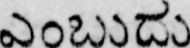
ಎಂಬುದು
